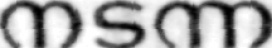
നടന്ന
